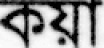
কয়া
